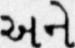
અને
